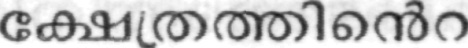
ക്ഷേത്രത്തിന്റെ
